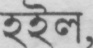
হইল,
